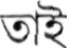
তাই
